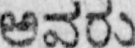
ಅವರು
